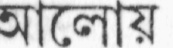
আলোয়
